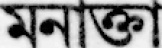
মনাক্তা
